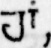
ਹਾਂ,
